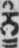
ਨੂੰ
